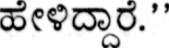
ಹೇಳಿದ್ದಾರೆ."
